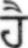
ਹੈ
